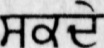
ਸਕਦੇ
